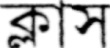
ক্লাস
